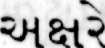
અક્ષરે
